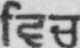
ਵਿਚ
